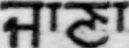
ਜਾਣਾ
